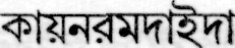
কায়নরমদাইদা
